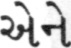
એને
